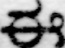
ಈ
